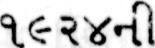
૧૯૨૪ની
